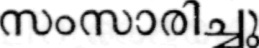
സംസാരിച്ചു
